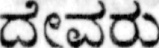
ದೇವರು
